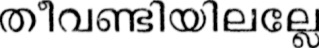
തീവണ്ടിയിലല്ലേ
